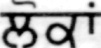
ਲੋਕਾਂ
